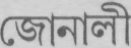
জোনালী
